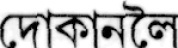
দোকানলৈ
